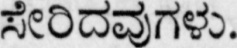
ಸೇರಿದವುಗಳು.
